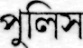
পুলিস
